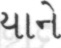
યાને
